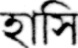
হাসি
